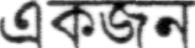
একজন
